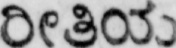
ರೀತಿಯ
